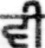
ਵੀ
